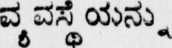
ವ್ಯವಸ್ಥೆಯನ್ನು
